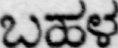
ಬಹಳ
